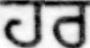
ਹਰ
